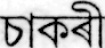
চাকৰী
